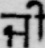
ਜੀ
